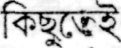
কিছুতেই
